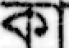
কা
